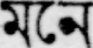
মনে
